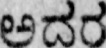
ಅದರ
